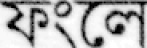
ফংলে
